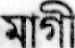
মাগী
